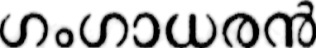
ഗംഗാധരന്‍
